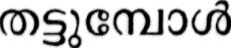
തട്ടുമ്പോള്‍
